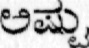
ಅಷ್ಟು
